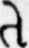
તે
